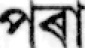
পৰা
